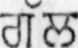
ਗੱਲ
